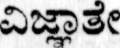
ವಿಜ್ಞಾತೇ
